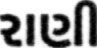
રાણી
